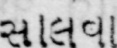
સાલવા
